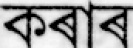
কৰাৰ
